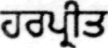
ਹਰਪ੍ਰੀਤ
